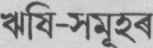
ঋষি-সমূহৰ
